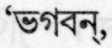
‘ভগবন্,
